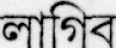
লাগিব
